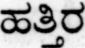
ಹತ್ತಿರ
